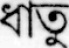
ধাতু
